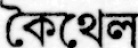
কৈথেল
